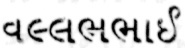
વલ્લભભાઈ
